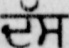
ਦੱਸ
